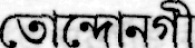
তোন্দোনগী
